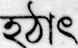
হঠাৎ
